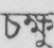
চক্ষু
